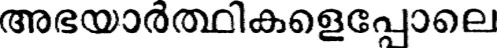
അഭയാര്‍ത്ഥികളെപ്പോലെ
